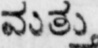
ಮತ್ತು
